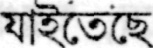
যাইতেছে
